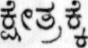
ಕ್ಷೇತ್ರಕ್ಕೆ
